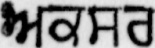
ਅਕਸਰ
